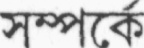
সম্পর্কে
